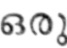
ഒരു
